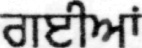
ਗਈਆਂ
